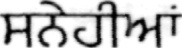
ਸਨੇਹੀਆਂ
